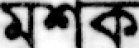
মশক
